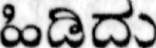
ಹಿಡಿದು
